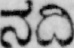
ನದಿ
